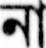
না
